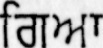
ਗਿਆ
